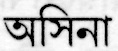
অসিনা
